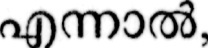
എന്നാല്‍,
